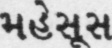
મહેસૂસ
